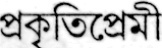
প্রকৃতিপ্রেমী
